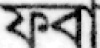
ফবা
